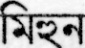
মিহুন
